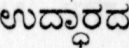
ಉದ್ಧಾರದ
